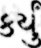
કર્યું
